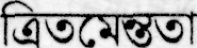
ত্রিতমেন্ততা
